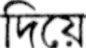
দিয়ে
